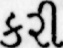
કરી
